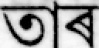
তাৰ
